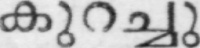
കുറച്ചു
